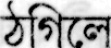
ঠগিলে
